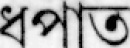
ধপাত
